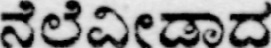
ನೆಲೆವೀಡಾದ
